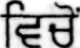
ਵਿਚੋਂ
